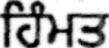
ਹਿੰਮਤ
